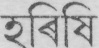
হৰিষি
